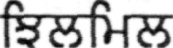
ਝਿਲਮਿਲ
